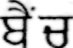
ਬੈਂਚ
